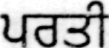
ਪਰਤੀ
